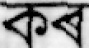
কৰ
